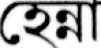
হেন্না
